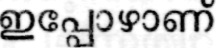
ഇപ്പോഴാണ്
